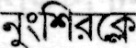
নুংশিরক্লে
